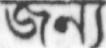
জন্য
